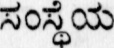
ಸಂಸ್ಥೆಯ
